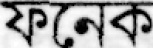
ফনেক
